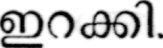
ഇറക്കി.
